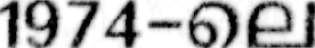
1974-ലെ
